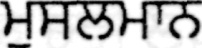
ਮੁਸਲਮਾਨ
